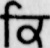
ਕਿ
